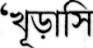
‘খূড়াসি
